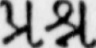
પ્રશ્ર
